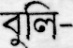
বুলি-
